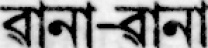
ৱানা-ৱানা
